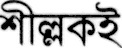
শীল্লকই
